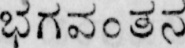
ಭಗವಂತನ
